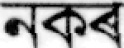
নকৰ
